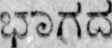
ಭಾಗದ
